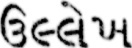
ઉલ્લેખ
